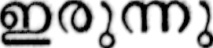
ഇരുന്നു
